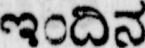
ಇಂದಿನ
